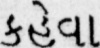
કહેવા
